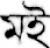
মই
